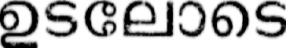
ഉടലോടെ
